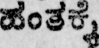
ಹಂತಕ್ಕೆ
